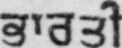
ਭਾਰਤੀ
